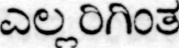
ಎಲ್ಲರಿಗಿಂತ
